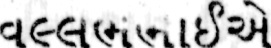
વલ્લભભાઈએ
